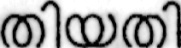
തിയതി
